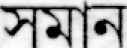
সমান
